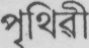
পৃথিৱী
